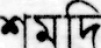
শমদি
